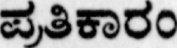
ಪ್ರತಿಕಾರಂ
